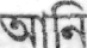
আনি
